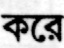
করে
